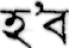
হ'ব
